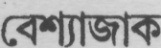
বেশ্যাজাক
